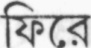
ফিরে
